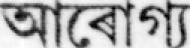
আৰোগ্য
